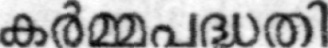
കര്‍മ്മപദ്ധതി
